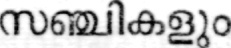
സഞ്ചികളും
